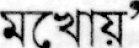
মখোয়’
